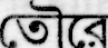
তৌরে
